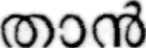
താന്‍
